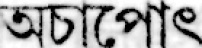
অচাপোৎ
